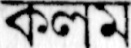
কলম
